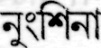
নুংশিনা
